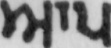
ਆਪ
